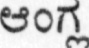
ಆಂಗ್ಲ
